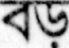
বড়
